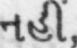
નહીં,
